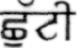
ਛੁੱਟੀ
